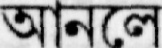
আনলে
